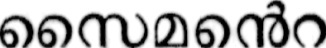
സൈമന്റെ
